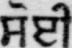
ਸੋਈ
